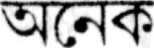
অনেক
